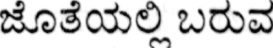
ಜೊತೆಯಲ್ಲಿಬರುವ
